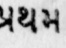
પ્રથમ
